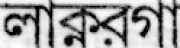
লাক্নরগা
